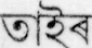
তাইৰ
